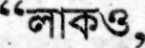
তূমিন্নরিসি
